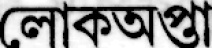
লোকঅপ্তা
